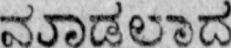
ಮಾಡಲಾದ
